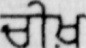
ਚੀਖ਼
